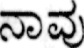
ನಾವು
